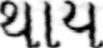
થાય
